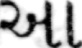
આ
